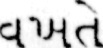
વખતે
